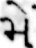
મેં
